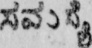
ಸಮಸ್ಯೆ
